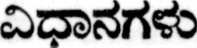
ವಿಧಾನಗಳು
